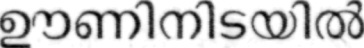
ഊണിനിടയില്‍
